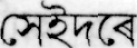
সেইদৰে
